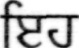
ਇਹ
